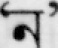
'ন'
